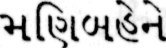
મણિબહેને
